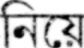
নিয়ে
